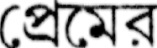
প্রেমের
